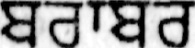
ਬਰਾਬਰ
